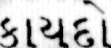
કાયદો
